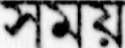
সময়
